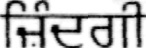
ਜ਼ਿੰਦਗੀ
